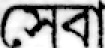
সেবা
